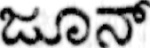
ಜೂನ್
